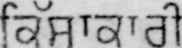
ਕਿੱਸਾਕਾਰੀ
